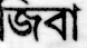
জিবা
